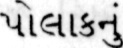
પોલાકનું
